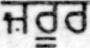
ਜ਼ਰੂਰ
